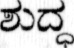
ಶುದ್ಧ
